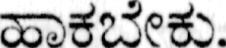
ಹಾಕಬೇಕು.
